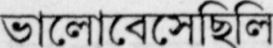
ভালোবেসেছিলি
